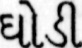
ઘોડી
